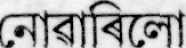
নোৱাৰিলো
